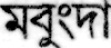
মবুংদা
